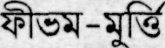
ফীভম-মুর্ত্তি
